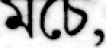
মচে,
